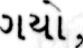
ગયો,
